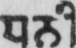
ਧਨੀ
